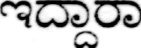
ಇದ್ದಾರಾ
